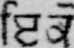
ਇਕੋ
